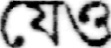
যেও
